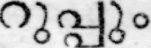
റുപ്പും
